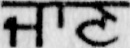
ਜਾਣ
